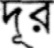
দূর
